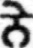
ਨੇ
